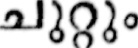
ചുറ്റും
